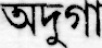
অদুগা
